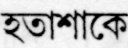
হতাশাকে
